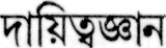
দায়িত্বজ্ঞান
